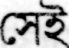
সেই
